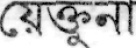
য়েক্তুনা
